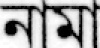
নামা
